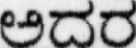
ಅದರ
